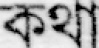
কথা
